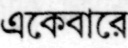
একেবারে
